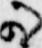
જે
